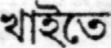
খাইতে
